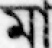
মা
